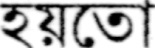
হয়তো
